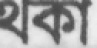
থকা
